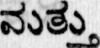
ಮತ್ತು
